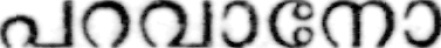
പറവാനോ
